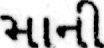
માની
